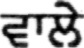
ਵਾਲੇ
